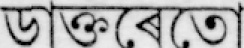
ডাক্তৰেতো
